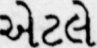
એટલે
